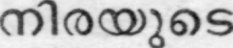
നിരയുടെ
